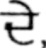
ਦੇ,
